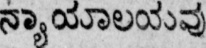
ನ್ಯಾಯಾಲಯವು
